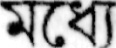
মধ্যে
